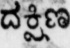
ದಕ್ಷಿಣ
